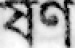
ষম
